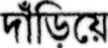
দাঁড়িয়ে
